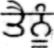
ਤੈਨੂੰ
